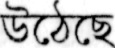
উঠেছে
